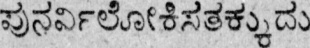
ಪುನರ್ವಿಲೋಕಿಸತಕ್ಕುದು
